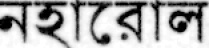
নহারোল
